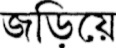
জড়িয়ে
